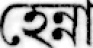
হেন্না
